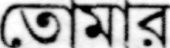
তোমার
